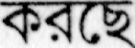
করছে
